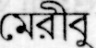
মেরীবু
